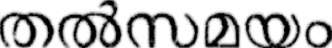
തല്‍സമയം
